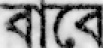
বাবে
